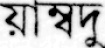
য়াম্বদু
